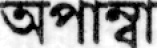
অপাম্বা
